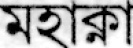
মহাক্না
